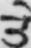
ਤੇ
